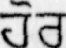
ਹੋਰ
